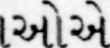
।ઓએ
